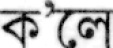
ক'লে
